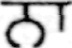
ਨਾ
